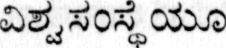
ವಿಶ್ವಸಂಸ್ಥೆಯೂ
